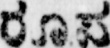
ರೂಪ
